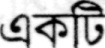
একটি
